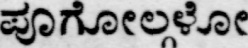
ಪೂಗೋಲ್ಗಳೋ
